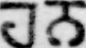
ਹਨ
